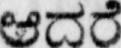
ಆದರೆ
